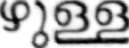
ഴുള്ള
